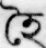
হৈ
